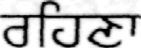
ਰਹਿਣਾ
